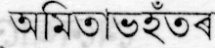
অমিতাভহঁতৰ
